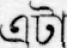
এটা
